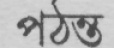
পঠন্ত
